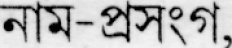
নাম-প্রসংগ,
